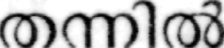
തന്നില്‍
